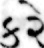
કરે
